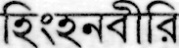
হিংহনবীরি
